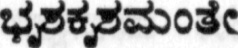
ಭೃಶಕೃಶಮಂತೇ
